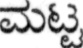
ಮಟ್ಟ
